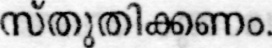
സ്തുതിക്കണം.
